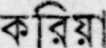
করিয়া
